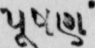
પૂષર્ણ
